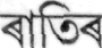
ৰাতিৰ
